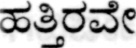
ಹತ್ತಿರವೇ
